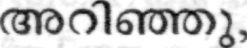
അറിഞ്ഞു,
